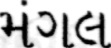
મંગલ
